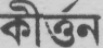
কীৰ্ত্তন
